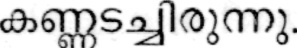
കണ്ണടച്ചിരുന്നു.
